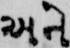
અને
